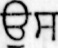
ਉਸ
